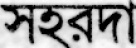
সহরদা
